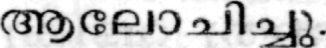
ആലോചിച്ചു.
